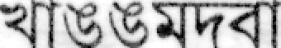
খাঙঙমদবা
